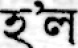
হ'ল
